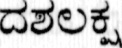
ದಶಲಕ್ಷ
